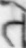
તે
